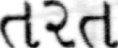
તરત
